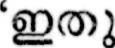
‘ഇതു
